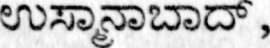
ಉಸ್ಮಾನಾಬಾದ್,
